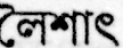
লৈশাৎ
